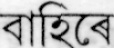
বাহিৰে
